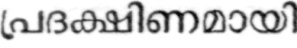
പ്രദക്ഷിണമായി
